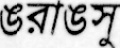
ঙরাঙসু
